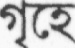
গৃহে
